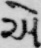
એ
